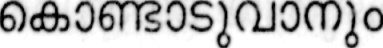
കൊണ്ടാടുവാനും
